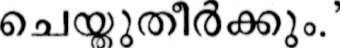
ചെയ്തുതീര്‍ക്കും.’
